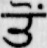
ਤੋਂ
